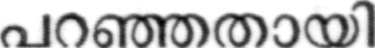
പറഞ്ഞതായി
